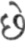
છે
